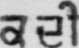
ਕਦੀ
